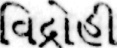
વિદ્રોહી
